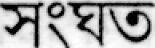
সংঘত
